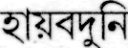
হায়বদুনি
